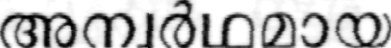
അന്വര്‍ഥമായ
